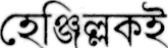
হেঞ্জিল্লকই
